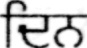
ਦਿਨ
